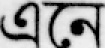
এনে
